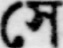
সে
